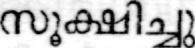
സൂക്ഷിച്ചു
